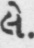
લે.
